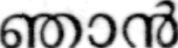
ഞാന്‍
